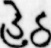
હેઠ
